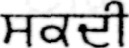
ਸਕਦੀ
